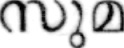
സുമ
